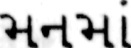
મનમાં
